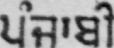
ਪੰਜਾਬੀ
